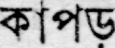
কাপড়
